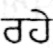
ਰਹੇ
